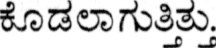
ಕೊಡಲಾಗುತ್ತಿತ್ತು.
